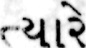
ત્યારે
